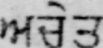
ਅਚੇਤ
